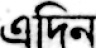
এদিন
